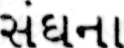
સંઘના
